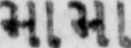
મામા
